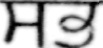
ਸਭ
